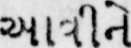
આવીને
